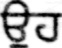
ਉਹ
